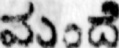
ಮಂದೆ
